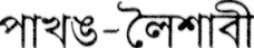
পাখঙ-লৈশাবী
